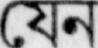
যেন
